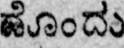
ದೊಂದು
